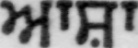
ਆਸ਼ਾ
